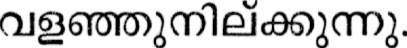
വളഞ്ഞുനില്ക്കുന്നു.
